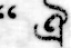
“ঐ
